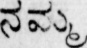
ನಮ್ಮ
